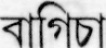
বাগিচা
